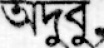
অদুবু,
